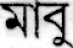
মাবু
